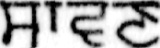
ਸਾਵਣ
